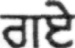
ਗਏ
